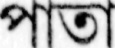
পাতা
